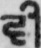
ਵੀ
